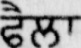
ਫੈਲਾ
